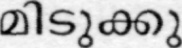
മിടുക്കു
